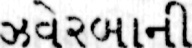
ઝવેરબાની
